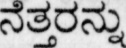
ನೆತ್ತರನ್ನು
